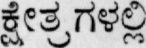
ಕ್ಷೇತ್ರಗಳಲ್ಲಿ
